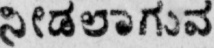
ನೀಡಲಾಗುವ
